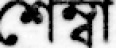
শেম্বা
